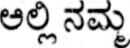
ಅಲ್ಲಿನಮ್ಮ
